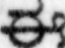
ಈ
